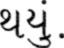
થયું.
